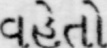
વહેતો
